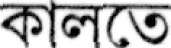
কালতে
